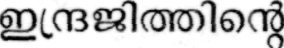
ഇന്ദ്രജിത്തിന്റെ
